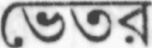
ভেতর
